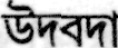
উদবদা
